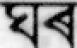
ঘৰ
